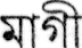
মাগী
